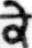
ਕੇ
